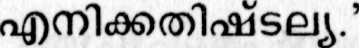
എനിക്കതിഷ്ടല്യ.’
